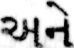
અને
